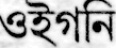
ওইগনি
